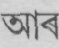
আৰ
